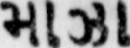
માઝા
